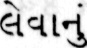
લેવાનું
